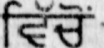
ਵਿੱਚੋਂ
